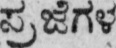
ಪ್ರಜೆಗಳ
